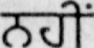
ਨਹੀਂ
